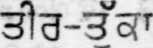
ਤੀਰ-ਤੁੱਕਾ
